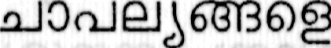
ചാപല്യങ്ങളെ
